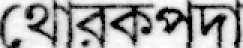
থোরকপদা
